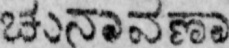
ಚುನಾವಣಾ
